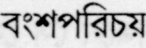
বংশপরিচয়
